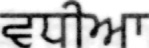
ਵਧੀਆ
